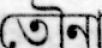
তৌনা
